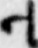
ન
